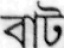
বাট
